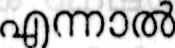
എന്നാല്‍
